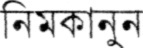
নিমকানুন
